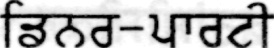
ਡਿਨਰ-ਪਾਰਟੀ
